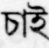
চাই
